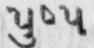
પુષ્પ
